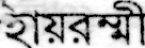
হায়রম্মী
